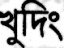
খুদিং
